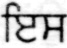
ਇਸ
